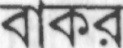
বাকর
